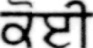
ਕੋਈ
